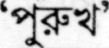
‘পুরুখ’
